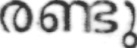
രണ്ടു
